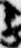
કે
